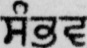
ਸੰਭਵ
